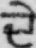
ਦੇ
